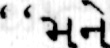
"મને
